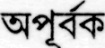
অপূর্বক
